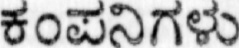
ಕಂಪನಿಗಳು
